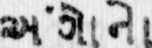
અંગોનો
